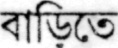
বাড়িতে
